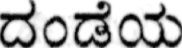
ದಂಡೆಯ
